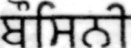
ਬੌਸਿਨੀ
